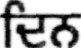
ਦਿਨ
